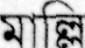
মাল্লি
